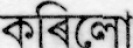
কৰিলো
